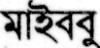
মাইববু
